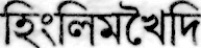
হিংলিমখৈদি
